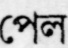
পেল
